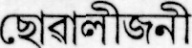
ছোৱালীজনী
